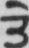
ਤੇ
